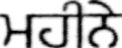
ਮਹੀਨੇ
